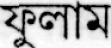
ফুলাম
